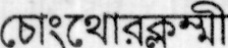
চোংথোরক্লম্মী
